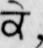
ਕੇ,
